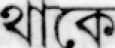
থাকে
